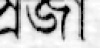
প্রজা
